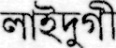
লাইদুগী
